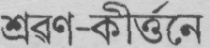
শ্ৰৱণ-কীৰ্ত্তনে
